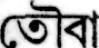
তৌবা
